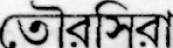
তৌরসিরা
